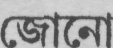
জোনো
